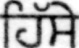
ਹਿੱਸੇ
